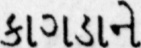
કાગડાને
